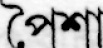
পৈশা
